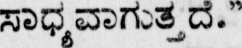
ಸಾಧ್ಯವಾಗುತ್ತದೆ.”
